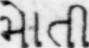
મોતી
